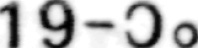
19-ാം
